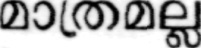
മാത്രമല്ല
